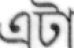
এটা
